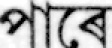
পাৰে
